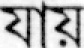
যায়
